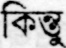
কিন্তু
